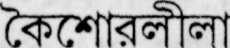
কৈশোরলীলা
